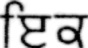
ਇਕ
